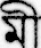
মী
